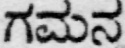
ಗಮನ
